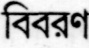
বিবরণ
